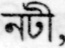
নটী,
